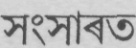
সংসাৰত
